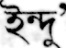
ইন্দু’
